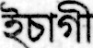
ইচাগী
